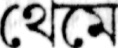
থেমে
